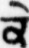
ਕੇ
